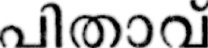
പിതാവ്
